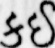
કઈ
